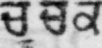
ਚੂਚਕ
